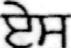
ਏਸ
